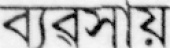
ব্যৱসায়
